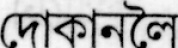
দোকানলৈ
